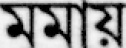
মমায়
